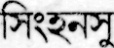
সিংহনসু
